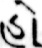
હો
